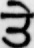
ਤੇ
